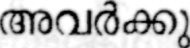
അവര്‍ക്കു
